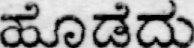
ಹೊಡೆದು
